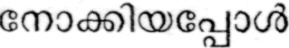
നോക്കിയപ്പോള്‍
